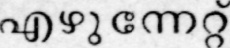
എഴുന്നേറ്റ്
